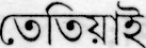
তেতিয়াই
